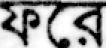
ফরে
